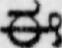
ಈ
